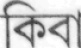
কিবা
